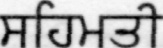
ਸਹਿਮਤੀ
